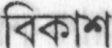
বিকাশ
